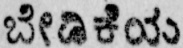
ಬೇಡಿಕೆಯ
